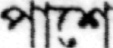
পাশে
